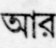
আর
